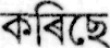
কৰিছে
